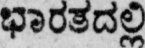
ಭಾರತದಲ್ಲಿ
